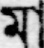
মা
